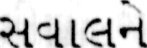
સવાલને
